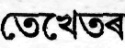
তেখেতৰ
